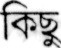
কিছু
